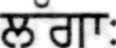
ਲੱਗਾ:
